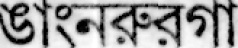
ঙাংনরুরগা
